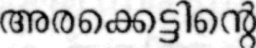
അരക്കെട്ടിന്റെ
